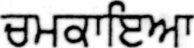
ਚਮਕਾਇਆ
